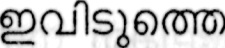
ഇവിടുത്തെ
